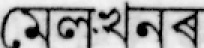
মেলখনৰ
